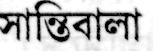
সান্তিবালা
